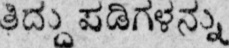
ತಿದ್ದುಪಡಿಗಳನ್ನು
